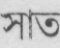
সাত
